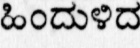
ಹಿಂದುಳಿದ
